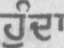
ਹੁੰਦਾ
